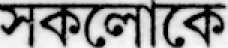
সকলোকে
